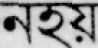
নহয়
